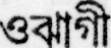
ওঝাগী
